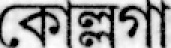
কোল্লগা
